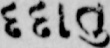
દદાતુ
